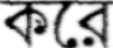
করে
